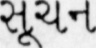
સૂચન
